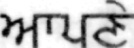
ਆਪਣੇ
